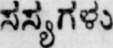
ಸಸ್ಯಗಳು
